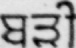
ਬੜੀ
